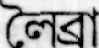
লৈব্রা
